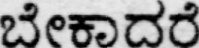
ಬೇಕಾದರೆ
